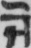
ਜੋ
